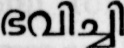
ഭവിച്ചി
